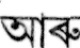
আৰু
